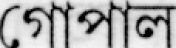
গোপাল
